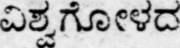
ವಿಶ್ವಗೋಳದ
